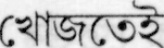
খোজতেই
